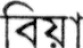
বিয়া
